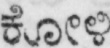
ಕೋಳಿ
